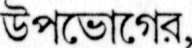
উপভোগের,
